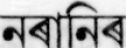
নৰানিৰ
